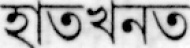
হাতখনত
